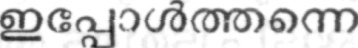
ഇപ്പോള്‍ത്തന്നെ
